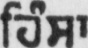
ਹਿੰਸਾ
